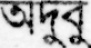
অদুবু
